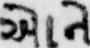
ઓને
